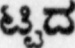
ಟ್ಟಿದ
